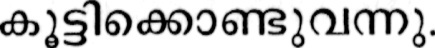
കൂട്ടിക്കൊണ്ടുവന്നു.
